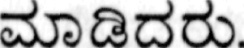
ಮಾಡಿದರು.
